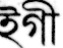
ইগী
